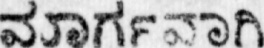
ಮಾರ್ಗವಾಗಿ
